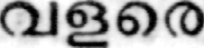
വളരെ
